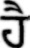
ਹੈ
